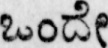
ಒಂದೇ
